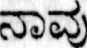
ನಾವು
